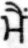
ਮੈਂ
